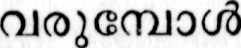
വരുമ്പോള്‍
